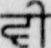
ਵੀ
